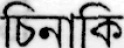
চিনাকি
